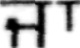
ਜਾ
